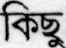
কিছু
